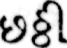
છઠ્ઠી
